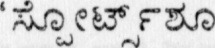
‘ಸ್ಪೋರ್ಟ್ಸ್‌ಶೂ
